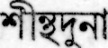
শীন্থদুনা
